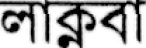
লাক্নবা
